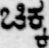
ಚಿಕ್ಕ
